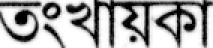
তংখায়কা
